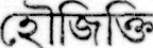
হৌজিক্তি
